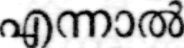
എന്നാല്‍
